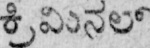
ಕ್ರಿಮಿನಲ್
